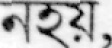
নহয়,
